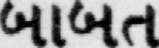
બાબત
